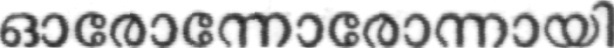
ഓരോന്നോരോന്നായി
